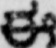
ಈ
